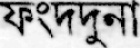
ফংদদুনা
